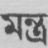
মন্ত্ৰ
